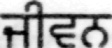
ਜੀਵਨ
